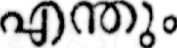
എന്തും
